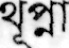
থূপ্না
